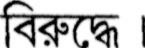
বিরুদ্ধে।
